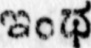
ಇಂಥ
